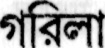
গরিলা
